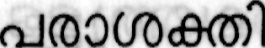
പരാശക്തി
